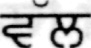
ਵੱਲ
